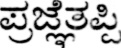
ಪ್ರಜ್ಞೆತಪ್ಪಿ
